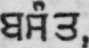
ਬਸੰਤ,
